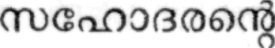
സഹോദരന്റെ
